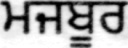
ਮਜਬੂਰ
